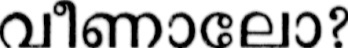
വീണാലോ?
